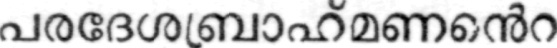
പരദേശബ്രാഹ്മണന്റെ
